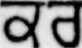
ਕਰ
